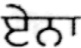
ਏਨਾ
